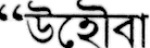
“উহৌবা
